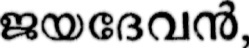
ജയദേവന്‍,
